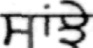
ਸਾਂਝੇ
